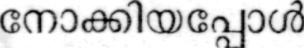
നോക്കിയപ്പോള്‍
